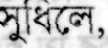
সুধিলে,
